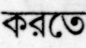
করতে
